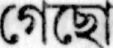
গেছো
